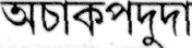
অচাকপদুদা
